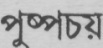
পুষ্পচয়
